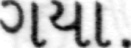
ગયા.
